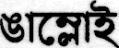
ঙাম্লোই
